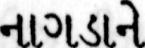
નાગડાને
